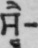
ਸ੍ਵੈ-
